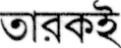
তারকই
